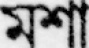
মশা
